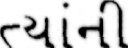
ત્યાંની
